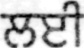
ਲਈ
